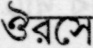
ঔরসে
